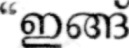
"ഇങ്ങ്
